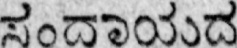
ಸಂದಾಯದ
